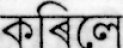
কৰিলে
